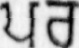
ਪਰ
